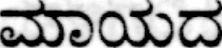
ಮಾಯದ
